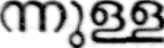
ന്നുള്ള
